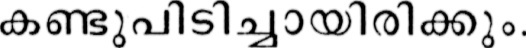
കണ്ടുപിടിച്ചായിരിക്കും.
